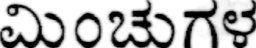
ಮಿಂಚುಗಳ
